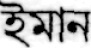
ইমান
